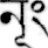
নূং
